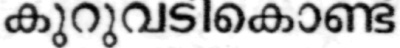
കുറുവടികൊണ്ട്
